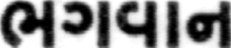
ભગવાન
